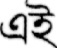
এই
